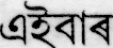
এইবাৰ
